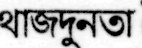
থাজদুনতা
